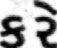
કરે
